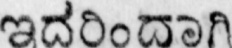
ಇದರಿಂದಾಗಿ
